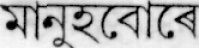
মানুহবোৰে
